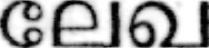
ലേഖ
